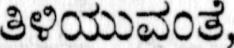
ತಿಳಿಯುವಂತೆ,
